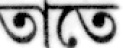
তাতে
